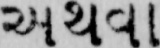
અથવા
